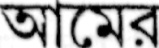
আমের
